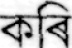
কৰি
